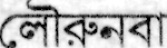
লৌরুনবা
